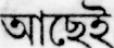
আছেই
